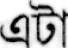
এটা
